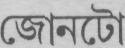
জোনটো
